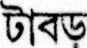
টাবড়
